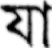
যা
